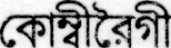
কোম্বীরৈগী
